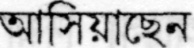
আসিয়াছেন
